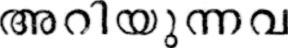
അറിയുന്നവ
